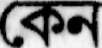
কেন
